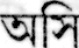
অসি
